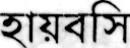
হায়বসি
